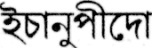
ইচানুপীদো
